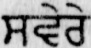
ਸਵੇਰੇ
